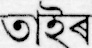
তাইৰ
